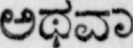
ಅಥವಾ
